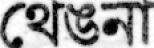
থেঙনা
